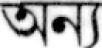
অন্য
